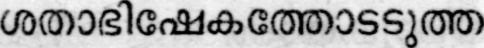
ശതാഭിഷേകത്തോടടുത്ത
